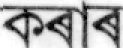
কৰাৰ
